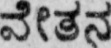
ವೇತನ
